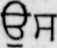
ਉਸ
